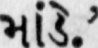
માંડે.'
